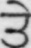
ਤੇ
